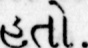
હતો.
